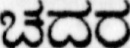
ಚದರ
